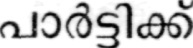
പാര്‍ട്ടിക്ക്
